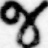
જ
